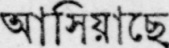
আসিয়াছে
